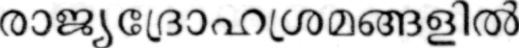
രാജ്യദ്രോഹശ്രമങ്ങളില്‍
